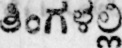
ತಿಂಗಳಲ್ಲಿ
